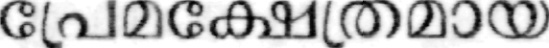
പ്രേമക്ഷേത്രമായ
